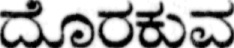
ದೊರಕುವ
